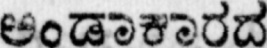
ಅಂಡಾಕಾರದ
